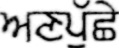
ਅਣਪੁੱਛੇ
